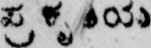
ಪ್ರಕೃತಿಯ
